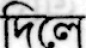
দিলে
